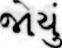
જોયું
